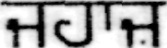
ਜਹਾਜ਼
